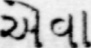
એવા
